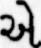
એ
